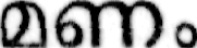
മണം
